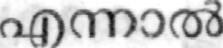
എന്നാല്‍
